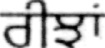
ਰੀਝਾਂ
